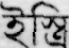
ইস্ত্রি
